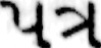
પત્ર
